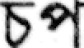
চপ
